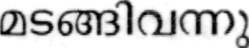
മടങ്ങിവന്നു
